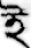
ই
